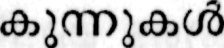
കുന്നുകള്‍
